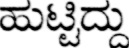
ಹುಟ್ಟಿದ್ದು
